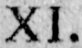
XI.
